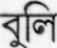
বুলি
